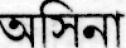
অসিনা
